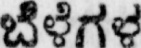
ಬೆಳೆಗಳ
